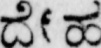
ದೇಹ
